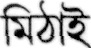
মিঠাই
